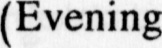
(Evening
